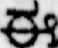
ಈ
